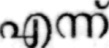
എന്ന്
